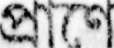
প্রাণে
